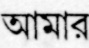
আমার
